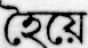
হৈয়ে
